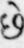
છે
